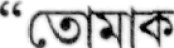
"তোমাক
